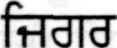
ਜਿਗਰ
